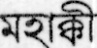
মহাক্কী
